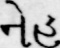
નેહ
